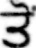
ਤੋਂ
